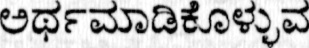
ಅರ್ಥಮಾಡಿಕೊಳ್ಳುವ
